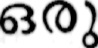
ഒരു
